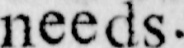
needs.
